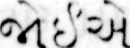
જોઈએ
